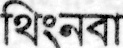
থিংনবা
